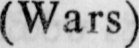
(Wars)
